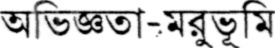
অভিজ্ঞতা-মরুভূমি
